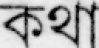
কথা
